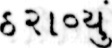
ઠરાવ્યું
